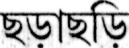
ছড়াছড়ি
